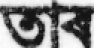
তাৰ
